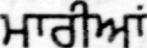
ਮਾਰੀਆਂ
